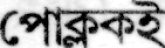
পোক্লকই
